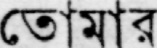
তোমার
